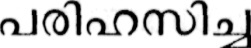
പരിഹസിച്ച
